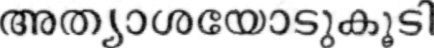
അത്യാശയോടുകൂടി
